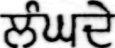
ਲੰਘਦੇ
